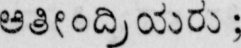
ಅತೀಂದ್ರಿಯರು;
